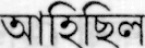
আহিছিল
